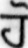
ਹੋ
